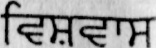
ਵਿਸ਼ਵਾਸ
